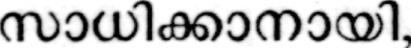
സാധിക്കാനായി,
